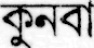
কুনবা
